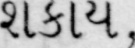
શકાય,
